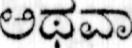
ಅಥವಾ
